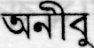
অনীবু
